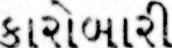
કારોબારી
